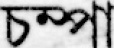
চম্পা
